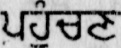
ਪਹੁੰਚਣ
